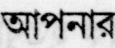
আপনার
